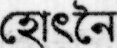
হোৎনৈ
